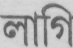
লাগি
